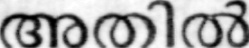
അതില്‍
